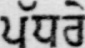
ਪੱਧਰੇ
